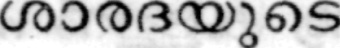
ശാരദയുടെ
